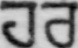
ਹਰ
